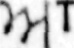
ਆ
